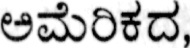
ಅಮೆರಿಕದ,
